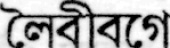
লৈবীবগে
